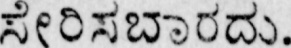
ಸೇರಿಸಬಾರದು.
